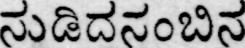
ನುಡಿದನಂಬಿನ
